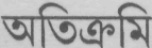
অতিক্ৰমি
